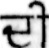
ਦੀ
